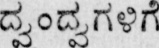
ದ್ವಂದ್ವಗಳಿಗೆ
